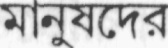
মানুষদের
